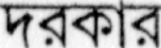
দরকার
